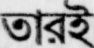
তারই
